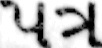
પત્ર
